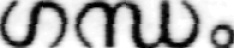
ഗന്ധം
